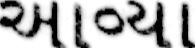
આવ્યા
